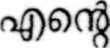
എന്റെ
